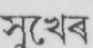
সুখেৰ
